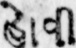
હોવી
